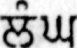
ਲੰਘ
